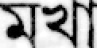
মখা
